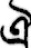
ঐ
